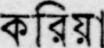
করিয়া
